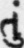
તું
